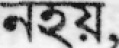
নহয়,
